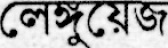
লেঙ্গুয়েজ
